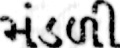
મંડળી
